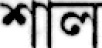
শাল
